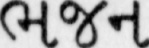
ભજન
